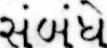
સંબંધે
